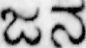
ಜನ
